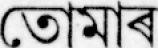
তোমাৰ
